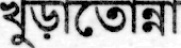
খুড়াতোন্না
